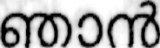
ഞാന്‍
